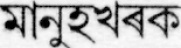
মানুহখৰক
